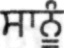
ਸਾਨੂੰ
